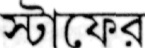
স্টাফের
